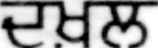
ਦਖ਼ਲ
